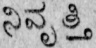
ನಿವೃತ್ತಿ
